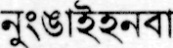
নুংঙাইহনবা
